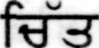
ਚਿੱਤ
